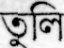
তুলি
